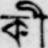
কী
